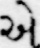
એ
